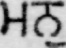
ਮਨੁ
